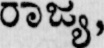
ರಾಜ್ಯ,
